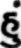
હું
